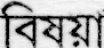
বিষয়া
